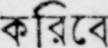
করিবে
